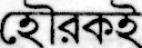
হৌরকই
